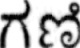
ಗಣಿ
